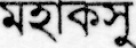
মহাকসু
